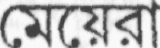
মেয়েরা
